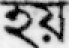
হয়
